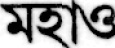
মহাও
